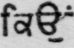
ਕਿਉਂ
